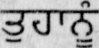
ਤੁਹਾਨੂੰ
